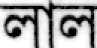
লাল
